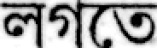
লগতে
